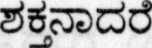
ಶಕ್ತನಾದರೆ
